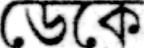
ডেকে
